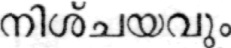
നിശ്ചയവും
